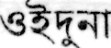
ওইদুনা
